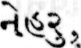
નેહરુ,
